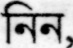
নিন,
